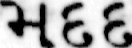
મદદ
